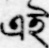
এই
